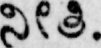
ನೀತಿ.
